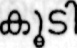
കൂടി
